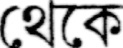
থেকে
